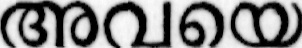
അവയെ
